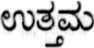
ಉತ್ತಮ
